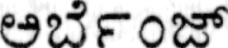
ಅರ್ಬೆಂಜ್
